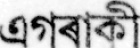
এগৰাকী
